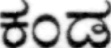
ಕಂಡ
